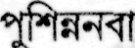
পুশিন্ননবা
